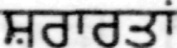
ਸ਼ਰਾਰਤਾਂ
